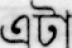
এটা
